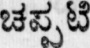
ಚಪ್ಪಟೆ
